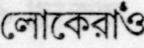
লোকেরাও
